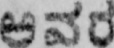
ಅವರ
